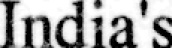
India's
